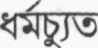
ধর্মচ্যুত
